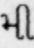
મી
